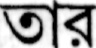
তার
